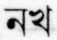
নখ
